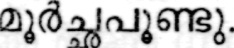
മൂര്‍ച്ഛപൂണ്ടു.
